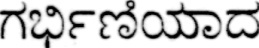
ಗರ್ಭಿಣಿಯಾದ
